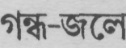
গন্ধ-জলে
